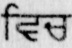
ਵਿਚ
